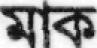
মাক
